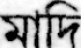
মাদি
